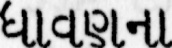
ધાવણના
